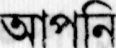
আপনি
